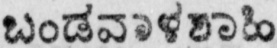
ಬಂಡವಾಳಶಾಹಿ
